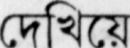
দেখিয়ে
